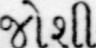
જોશી
